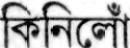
কিনিলোঁ
